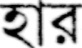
হার
